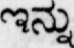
ಇನ್ನು
